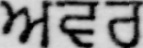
ਅਵਰ
